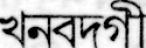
খনবদগী
